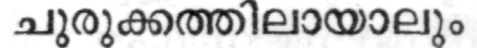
ചുരുക്കത്തിലായാലും
